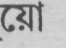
য়ো
